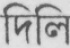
দিলি
